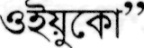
ওইয়ুকো”
